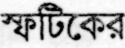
স্ফটিকের
